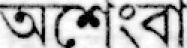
অশেংবা
